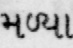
મળ્યા
